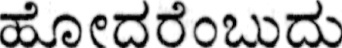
ಹೋದರೆಂಬುದು
